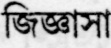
জিজ্ঞাসা
